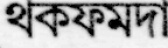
থকফমদা
